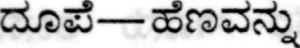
ದೂಪೆ-ಹೆಣವನ್ನು
